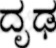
ದೃಢ
